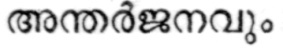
അന്തര്‍ജനവും
